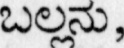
ಬಲ್ಲನು,
